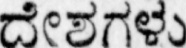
ದೇಶಗಳು
